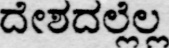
ದೇಶದಲ್ಲೆಲ್ಲ
